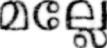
മല്ലേ
